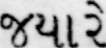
જ્યારે
